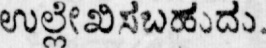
ಉಲ್ಲೇಖಿಸಬಹುದು.
